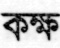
কক্ষ
